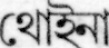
থোইনা
